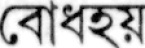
বোধহয়
